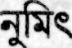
নুমিৎ
